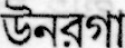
উনরগা
